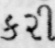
કરી
